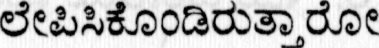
ಲೇಪಿಸಿಕೊಂಡಿರುತ್ತಾರೋ
